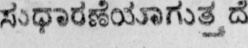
ಸುಧಾರಣೆಯಾಗುತ್ತದೆ
